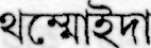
থম্মোইদা
